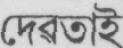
দেৱতাই
